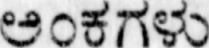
ಅಂಕಗಳು
